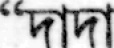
“দাদা
